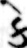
કે
